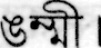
ঙম্মী।
